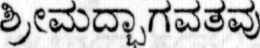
ಶ್ರೀಮದ್ಭಾಗವತವು
